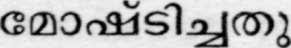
മോഷ്ടിച്ചതു
